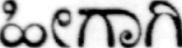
ಹೀಗಾಗಿ
